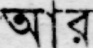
আর
